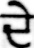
ਦੇ
